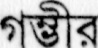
গম্ভীর
